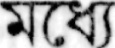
মধ্যে
